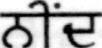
ਨੀਂਦ
